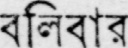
বলিবার
